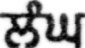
ਲੰਘ
